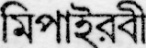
মিপাইরবী
